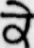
ਕੇ
